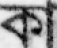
কা
